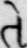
તે
